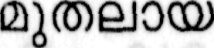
മുതലായ
